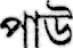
পাউ
